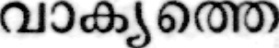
വാക്യത്തെ
